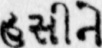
હસીને
